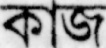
কাজ
